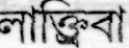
লাক্ত্রিবা
